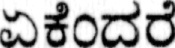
ಏಕೆಂದರೆ
